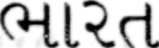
ભારત
